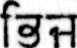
ਭਿਜ
